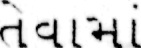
તેવામાં
